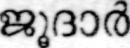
ജൂദാര്‍
